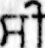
ਸੀ
